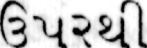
ઉપરથી
